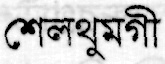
শেলথুমগী
